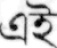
এই
